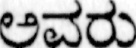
ಅವರು
